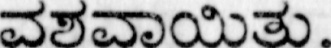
ವಶವಾಯಿತು.
